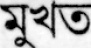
মুখত
